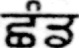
ਛੰਡ
